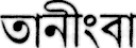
তানীংবা
